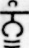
ਨੂੰ
